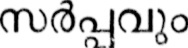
സര്‍പ്പവും
